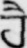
ਹੈ
